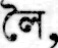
লৈ,
